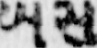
બસ
